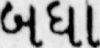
બધા
